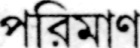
পরিমাণ
